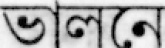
ভালনে
